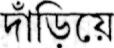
দাঁড়িয়ে
